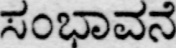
ಸಂಭಾವನೆ
